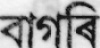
বাগৰি
